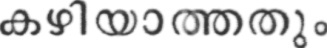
കഴിയാത്തതും
